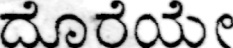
ದೊರೆಯೇ
